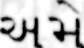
અમે
